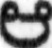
ಆ
